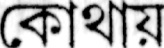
কোথায়
